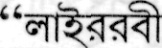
“লাইররবী
